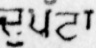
ਦੁਪੱਟਾ
